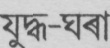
যুদ্ধ-ঘৰা
